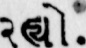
રહ્યો.
